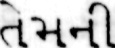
તેમની
